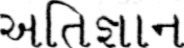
અતિજ્ઞાન
